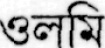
ওলমি
